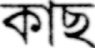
কাছ
